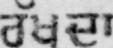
ਰੱਖਦਾ
